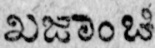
ಖಜಾಂಚಿ
